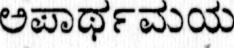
ಅಪಾರ್ಥಮಯ
